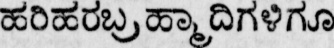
ಹರಿಹರಬ್ರಹ್ಮಾದಿಗಳಿಗೂ
